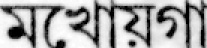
মখোয়গা
